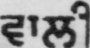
ਵਾਲੀ
